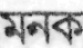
মনক
